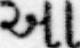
આ
